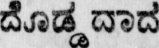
ದೊಡ್ಡದಾದ
